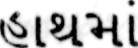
હાથમાં
